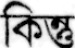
কিন্তু
